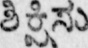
ಶಿಕ್ಷಿಸು
